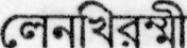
লেনখিরম্মী
